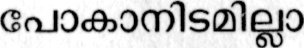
പോകാനിടമില്ലാ
